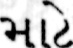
માટે
